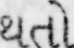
થતો
